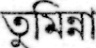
তুমিন্না
